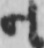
ન
